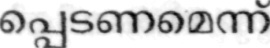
പ്പെടണമെന്ന്
